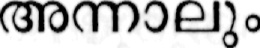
അന്നാലും
